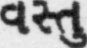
વસ્તુ
